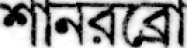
শানরব্রো
